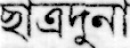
ছাত্রদুনা
